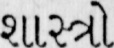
શાસ્ત્રો
